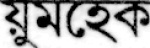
য়ুমহেক
